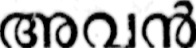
അവന്‍
